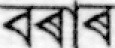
বৰাৰ
